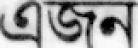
এজন
